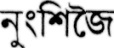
নুংশিজৈ
